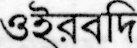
ওইরবদি
